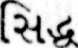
સિદ્ધ
